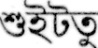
শুইটতু
